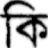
কি
